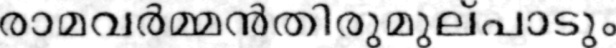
രാമവര്‍മ്മന്‍തിരുമുല്പാടും
